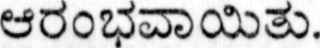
ಆರಂಭವಾಯಿತು.
